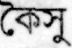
কৈসু
